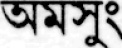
অমসুং
